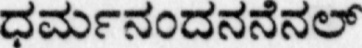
ಧರ್ಮನಂದನನೆನಲ್
